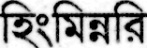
হিংমিন্নরি
